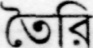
তৈরি
